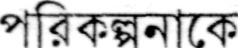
পরিকল্পনাকে
